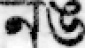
নঙ
